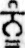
ਨੂੰ
